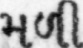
મળી
